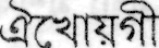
ঐখোয়গী
